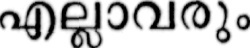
എല്ലാവരും
